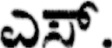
ಎಸ್.
